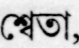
শ্বেতা,
